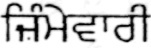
ਜ਼ਿੰਮੇਵਾਰੀ
